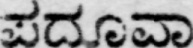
ಪದೂವಾ
